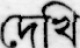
দেখি
